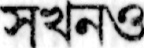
সখনও
